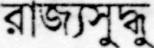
রাজ্যসুদ্ধু
